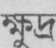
ক্ষুদ্ৰ
